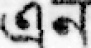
এন
